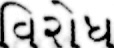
વિરોધ
